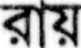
রায়
